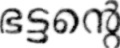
ഭട്ടന്റെ
